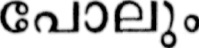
പോലും
